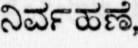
ನಿರ್ವಹಣೆ,
